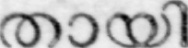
തായി
